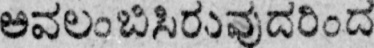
ಅವಲಂಬಿಸಿರುವುದರಿಂದ
